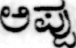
ಅಪ್ಪು
